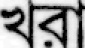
খরা
